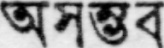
অসম্ভব
